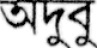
অদুবু
